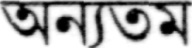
অন্যতম
